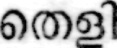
തെളി
